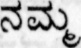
ನಮ್ಮ
